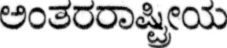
ಅಂತರರಾಷ್ಟ್ರೀಯ
